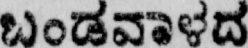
ಬಂಡವಾಳದ
